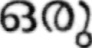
ഒരു
